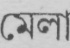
মেলা
